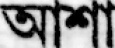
আশা
